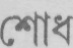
শোধ
